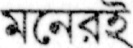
মনেরই
